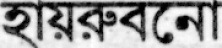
হায়রুবনো
